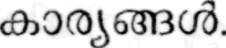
കാര്യങ്ങള്‍.
